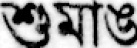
শুমাঙ
